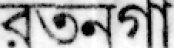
রতনগা
